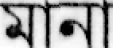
মানা
